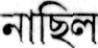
নাছিল
